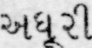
અધૂરી
